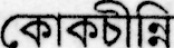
কোকচীন্নি
